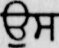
ਉਸ
